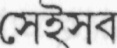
সেইসব
